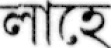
লাহে
